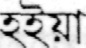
হইয়া
